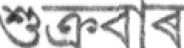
শুক্রবাৰ
